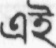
এই
